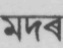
মদৰ
